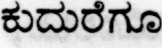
ಕುದುರೆಗೂ
